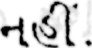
નહીં.
